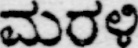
ಮರಳಿ
